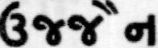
ઉજજૈન
